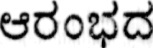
ಆರಂಭದ
